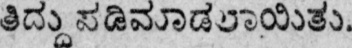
ತಿದ್ದುಪಡಿಮಾಡಲಾಯಿತು.
